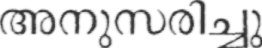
അനുസരിച്ചു
